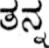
ತನ್ನ
